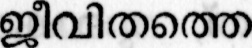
ജീവിതത്തെ
